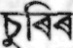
চুৰিৰ
